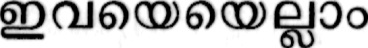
ഇവയെയെല്ലാം
